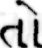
તો
